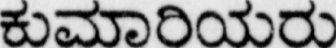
ಕುಮಾರಿಯರು
